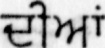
ਦੀਆਂ
